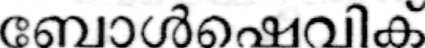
ബോള്‍ഷെവിക്
